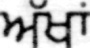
ਅੱਖਾਂ
